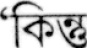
'কিন্তু
